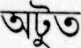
অটুত
